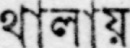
থালায়
